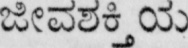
ಜೀವಶಕ್ತಿಯ
